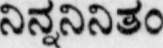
ನಿನ್ನನಿನಿತಂ
